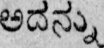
ಅದನ್ನು
